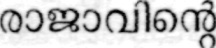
രാജാവിന്റെ
